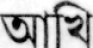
আখি
